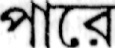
পারে
